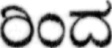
ರಿಂದ
